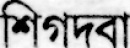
শিগদবা
